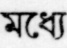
মধ্যে
